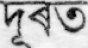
দূৰত
